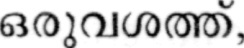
ഒരുവശത്ത്,
